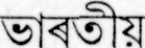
ভাৰতীয়
